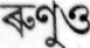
ৰুণুও
